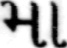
મા
